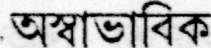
অস্বাভাবিক
